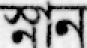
স্নান
